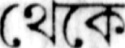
থেকে
